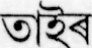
তাইৰ
